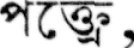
পক্ত্রে,
